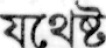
যথেষ্ট
